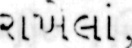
રાખેલાં,
